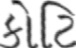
કોટી
